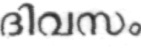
ദിവസം
